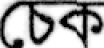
চেক
